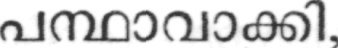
പന്ഥാവാക്കി,
